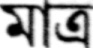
মাত্র
